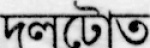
দলটোত
